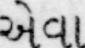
એવા
